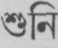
শুনি
